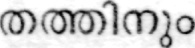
തത്തിനും
